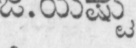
ಜಿ.ಯಷ್ಟು
